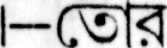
৷-—তোর
